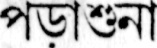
পড়াশুনা
